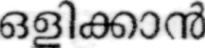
ഒളിക്കാന്‍
